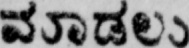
ಮಾಡಲು
